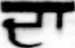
ਦਾ
